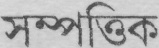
সম্পত্তিক
